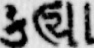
કહ્યા
